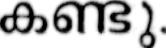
കണ്ടു.
